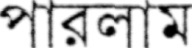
পারলাম
